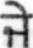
ਜੇ
